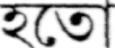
হতো
